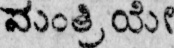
ಮಂತ್ರಿಯೇ
